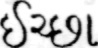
ઈચ્છા
